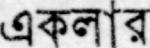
একলার
